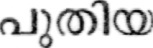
പുതിയ
